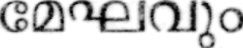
മേഘവും
